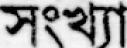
সংখ্যা
